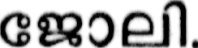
ജോലി.
